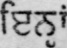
ਇਨ੍ਹਾਂ
